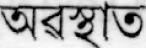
অৱস্হাত
